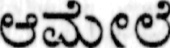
ಆಮೇಲೆ
